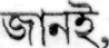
জানই,
